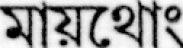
মায়থোং
